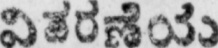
ವಿತರಣೆಯ
